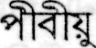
পীবীয়ু
